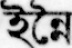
ইন্নৈ
